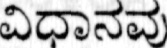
ವಿಧಾನವು
